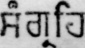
ਸੰਗ੍ਰਹਿ
